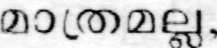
മാത്രമല്ല,
